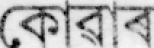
কোৱাৰ
